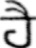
ਹੈ
